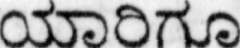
ಯಾರಿಗೂ
